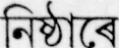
নিষ্ঠাৰে
